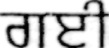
ਗਈ
